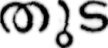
തുട
